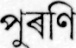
পুৰণি
